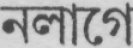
নলাগে
